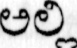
ಅಲ್ಲಿ
